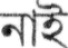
নাই
